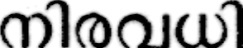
നിരവധി
